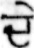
ਦੇ
